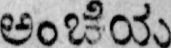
ಅಂಚೆಯ
